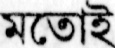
মতোই
